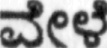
ವೇಳೆ
